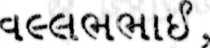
વલ્લભભાઈ,
